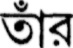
তাঁর
